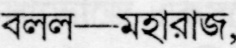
বলল–মহারাজ,
